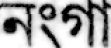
নংগা
